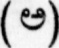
(ಅ)
